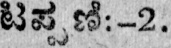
ಟಿಪ್ಪಣಿ:-2.
